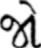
જો
